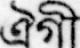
ঐগী
